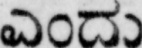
ಎಂದು
